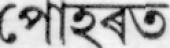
পোহৰত
